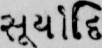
સૂર્યાદિ
